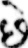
છે
